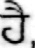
ਹੈ,
